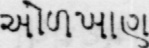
ઓળખાણ
